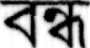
বন্ধ
